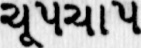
ચૂપચાપ
